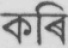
কৰি
